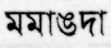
মমাঙদা
